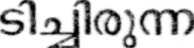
ടിച്ചിരുന്ന
